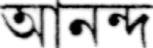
আনন্দ
